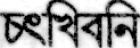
চৎখিবনি
